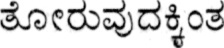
ತೋರುವುದಕ್ಕಿಂತ
